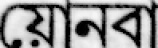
য়োনবা
